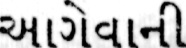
આગેવાની
